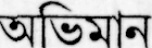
অভিমান
